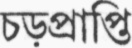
চড়প্রাপ্তি
